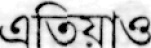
এতিয়াও
